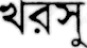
খরসু
